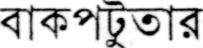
বাকপটুতার
